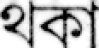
থকা
